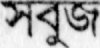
সবুজ
